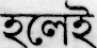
হলেই
